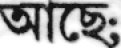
আছে;
